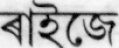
ৰাইজে
